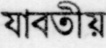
যাবতীয়
